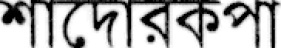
শাদোরকপা
